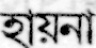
হায়না
